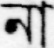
না
